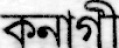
কনাগী
